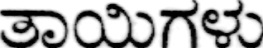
ತಾಯಿಗಳು
